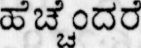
ಹೆಚ್ಚೆಂದರೆ
